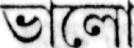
ভালো
